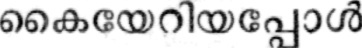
കൈയേറിയപ്പോള്‍
